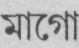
মাগো
